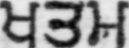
ਖਤਮ
